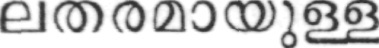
ലതരമായുള്ള
